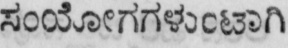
ಸಂಯೋಗಗಳುಂಟಾಗಿ
